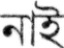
নাই
